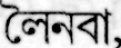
লৈনবা,
